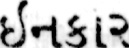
ઇનકાર
